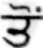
ਤੋਂ
